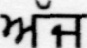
ਅੱਜ
